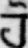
ਹੋ
